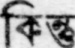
কিন্তু
